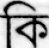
কি
